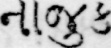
નાજુક
